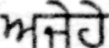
ਅਜੇਹੇ
